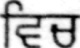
ਵਿਚ
